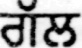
ਗੱਲ
